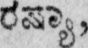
ರಷ್ಯಾ,
